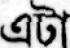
এটা
